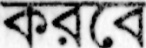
করবে
